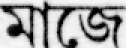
মাজে
